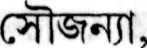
সৌজন্যা,
